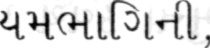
યમભાગિની,
